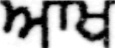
ਆਖ
